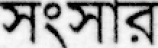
সংসার
